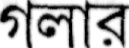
গলার
